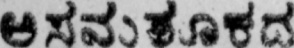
ಅಸಮತೂಕದ
